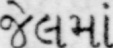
જેલમાં
